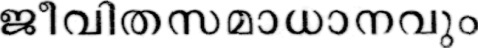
ജീവിതസമാധാനവും
